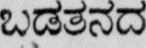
ಬಡತನದ
